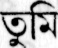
তুমি
